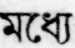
মধ্যে
